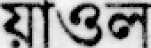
য়াওল
